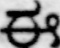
ಈ
